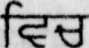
ਵਿਚ
